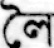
লৈ
